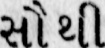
સૌથી
